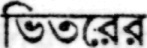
ভিতরের
